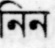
নিন
